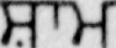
ਸ਼ਾਮ
